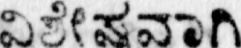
ವಿಶೇಷವಾಗಿ
